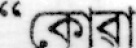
"কোৱা
